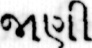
જાણી
